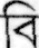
বি
